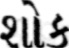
શોક
